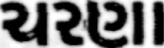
ચરણા
